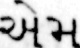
એમ
